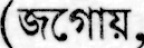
(জগোয়,
